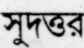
সুদত্তর
